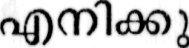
എനിക്കു
